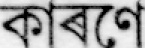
কাৰণে
